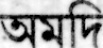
অমদি
